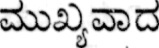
ಮುಖ್ಯವಾದ
